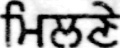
ਮਿਲਣੇ
